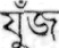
যুঁজ
